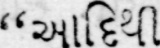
"આદિથી
